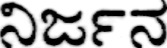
ನಿರ್ಜನ
